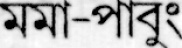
মমা-পাবুং
